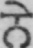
ਨੇ
